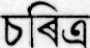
চৰিত্র
